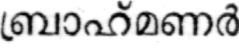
ബ്രാഹ്മണര്‍
